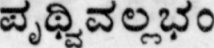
ಪೃಥ್ವಿವಲ್ಲಭಂ
